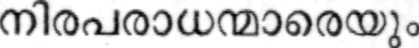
നിരപരാധന്മാരെയും
